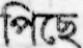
পিছে
